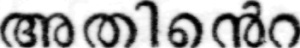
അതിന്റെ
